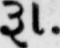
રૂ।.
